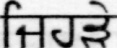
ਜਿਹੜੇ
